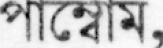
পাম্বোম,
